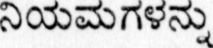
ನಿಯಮಗಳನ್ನು
